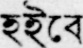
হইবে
